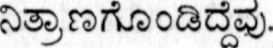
ನಿತ್ರಾಣಗೊಂಡಿದ್ದೆವು.
